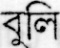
বুলি
